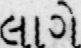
લાગે
